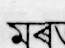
মৰ
